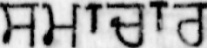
ਸਮਾਚਾਰ
